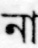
না
